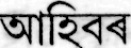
আহিবৰ
